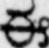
ಈ
